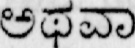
ಅಥವಾ
